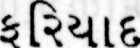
ફરિયાદ
